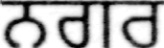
ਨਗਰ
